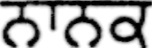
ਨਾਨਕ
